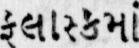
ફલાસ્કમાં
